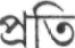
প্রতি
